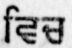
ਵਿਚ
